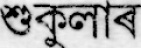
শুকুলাৰ
